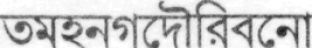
তমহনগদৌরিবনো
